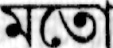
মতো
